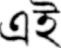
এই
